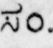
ಸಂ.
